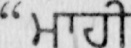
''ਮਾਹੀ
